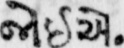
જોઈએ.
